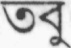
তবু
